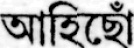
আহিছোঁ
